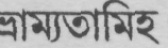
ভ্রাম্যতামিহ
